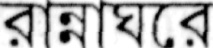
রান্নাঘরে
